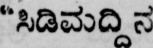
“ಸಿಡಿಮದ್ದಿನ
